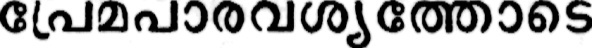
പ്രേമപാരവശ്യത്തോടെ
